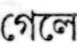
গেলে
